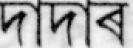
দাদাৰ
